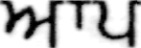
ਆਪ
